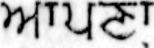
ਆਪਣਾ
